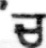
'ਚ
